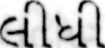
લીધી
